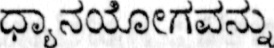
ಧ್ಯಾನಯೋಗವನ್ನು
